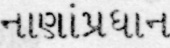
નાણાંપ્રધાન
